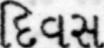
દિવસ
